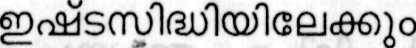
ഇഷ്ടസിദ്ധിയിലേക്കും
